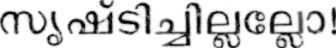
സൃഷ്ടിച്ചില്ലല്ലോ!
